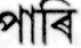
পাৰি
